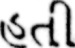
હતી
